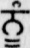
ਨੂੰ
